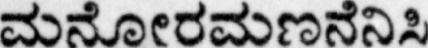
ಮನೋರಮಣನೆನಿಸಿ
